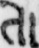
તો
